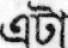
এটা
